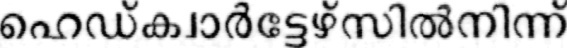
ഹെഡ്ക്വാര്‍ട്ടേഴ്സില്‍നിന്ന്
